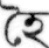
হৈ
